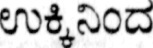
ಉಕ್ಕಿನಿಂದ
